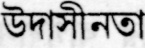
উদাসীনতা
